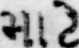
માટે
